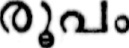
രൂപം
